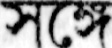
সঙ্গে
